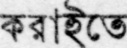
করাইতে
